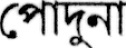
পোদুনা
